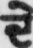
ਦੇ
